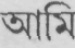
আমি
